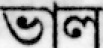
ভাল
